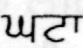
ਘਟਾ
